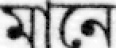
মানে
